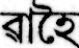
ৱাহৈ
